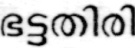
ഭട്ടതിരി
